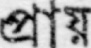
প্রায়
